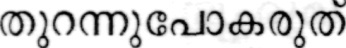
തുറന്നുപോകരുത്
